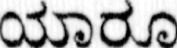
ಯಾರೂ
